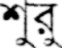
শুরু
